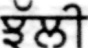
ਝੱਲੀ
